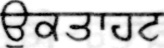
ਉਕਤਾਹਟ
